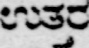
ಉತ್ತರ
